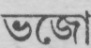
ভজো
